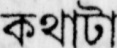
কথাটা
